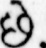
છે.
